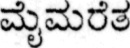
ಮೈಮರೆತ
